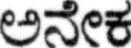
ಅನೇಕ
